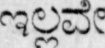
ಇಲ್ಲವೇ
